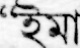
“ইমা
